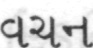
વચન
